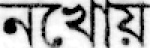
নখোয়
